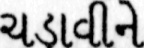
ચડાવીને
